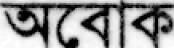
অবোক
